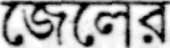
জেলের
